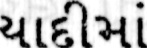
યાદીમાં
